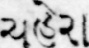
ચહેરા
